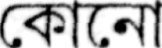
কোনো
